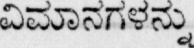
ವಿಮಾನಗಳನ್ನು
